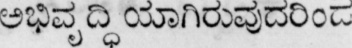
ಅಭಿವೃದ್ಧಿಯಾಗಿರುವುದರಿಂದ
